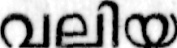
വലിയ
